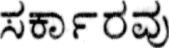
ಸರ್ಕಾರವು
